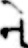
ને
